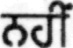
ਨਹੀਂ
